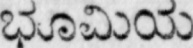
ಭೂಮಿಯ
